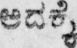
ಅದಕ್ಕೆ
